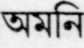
অমনি
